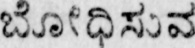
ಬೋಧಿಸುವ
